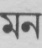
মন
